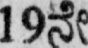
19ನೇ
